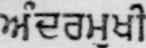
ਅੰਦਰਮੁਖੀ
